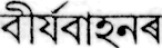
বীর্যবাহনৰ
